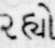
રહ્યો
